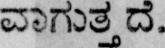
ವಾಗುತ್ತದೆ.
